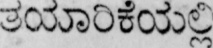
ತಯಾರಿಕೆಯಲ್ಲಿ
